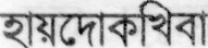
হায়দোকখিবা
